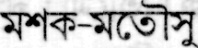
মশক-মতৌসু
